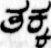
ತಕ್ಕ
